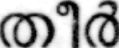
തീര്‍
